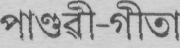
পাণ্ডৱী-গীতা
